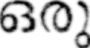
ഒരു
